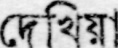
দেখিয়া
